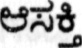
ಆಸಕ್ತಿ
